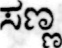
ಸಣ್ಣ
